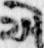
એ
